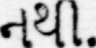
નથી.
